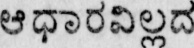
ಆಧಾರವಿಲ್ಲದ
